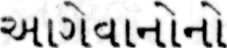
આગેવાનોનો
